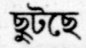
ছুটছে
